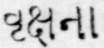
વૃક્ષના
